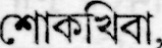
শোকখিবা,
